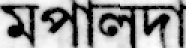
মপালদা
